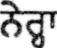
ਨੇਰ੍ਹਾ
